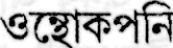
ওন্থোকপনি
